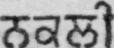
ਨਕਲੀ
